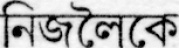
নিজলৈকে
